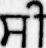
ਸੀ
